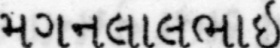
મગનલાલભાઈ
